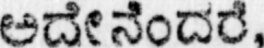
ಅದೇನೆಂದರೆ,
